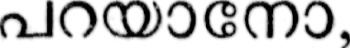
പറയാനോ,
